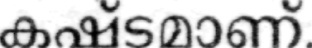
കഷ്ടമാണ്.
